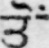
ਤੋਂ
